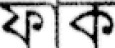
ফাক
